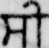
ਸੀ
